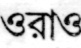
ওরাও
